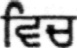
ਵਿਚ
